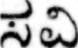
ಸವಿ
